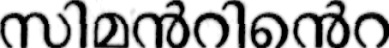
സിമന്റിന്റെ
